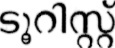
ടൂറിസ്റ്റ്
